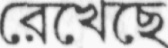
রেখেছে
